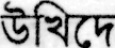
উখিদে
